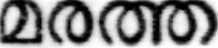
മരത്ത
